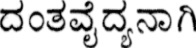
ದಂತವೈದ್ಯನಾಗಿ
